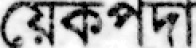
য়েকপদা
